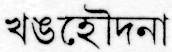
খঙহৌদনা
